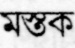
মস্তক
